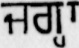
ਜਗ੍ਹਾ
